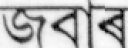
জবাৰ
